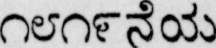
೧೮೧೯ನೆಯ
